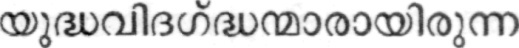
യുദ്ധവിദഗ്ദ്ധന്മാരായിരുന്ന
